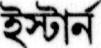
ইস্টার্ন
